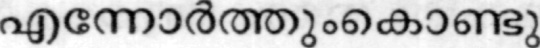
എന്നോര്‍ത്തുംകൊണ്ടു
